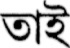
তাই
